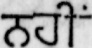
ਨਹੀਂ
